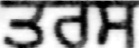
ਤਰਸ
